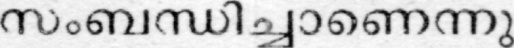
സംബന്ധിച്ചാണെന്നു
